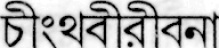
চীংথবীরীবনা
